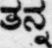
ತನ್ನ
